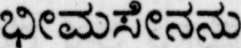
ಭೀಮಸೇನನು
